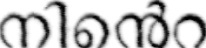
നിന്റെ
